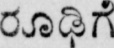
ರೂಢಿಗೆ
